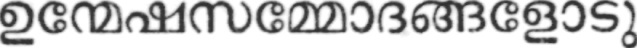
ഉന്മേഷസമ്മോദങ്ങളോടു
